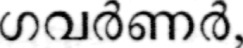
ഗവര്‍ണര്‍,
